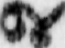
જ
